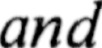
and
